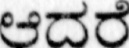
ಆದರೆ
